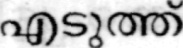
എടുത്ത്
